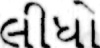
લીધો
